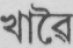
খাৱৈ
